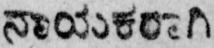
ನಾಯಕರಾಗಿ
